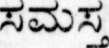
ಸಮಸ್ತ
